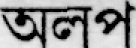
অলপ
